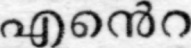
എന്റെ
